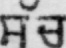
ਸੱਚ
